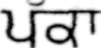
ਪੱਕਾ
